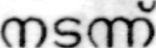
നടന്ന്
